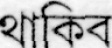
থাকিব
